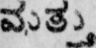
ಮತ್ತು
